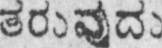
ತರುವುದು
